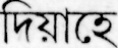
দিয়াহে
